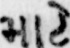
માટે
